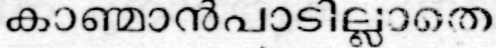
കാണ്മാന്‍പാടില്ലാതെ
